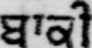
ਬਾਕੀ
